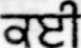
ਕਈ
